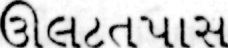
ઊલટતપાસ
